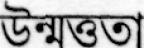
উন্মত্ততা
